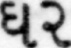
ઘર
